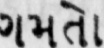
ગમતો
